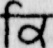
ਕਿ
